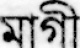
মাগী
